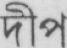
দীপ
